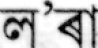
ল'ৰা
